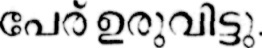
പേര്ഉരുവിട്ടു.
